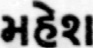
મહેશ
